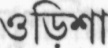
ওড়িশা
